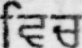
ਵਿਚ
